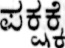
ಪಕ್ಷಕ್ಕೆ
